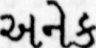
અનેક
